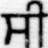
ਸੀ
